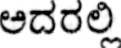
ಅದರಲ್ಲಿ
